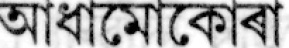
আধামোকোৰা
